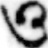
ও
